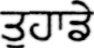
ਤੁਹਾਡੇ
